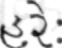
હરેઃ
